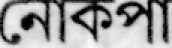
নোকপা
